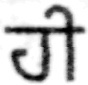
ਹੀ
